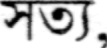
সত্য,
